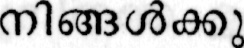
നിങ്ങള്‍ക്കു
